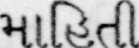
માહિતી
